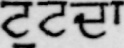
ਟੁਟਦਾ
